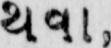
થવા,
